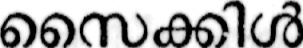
സൈക്കിള്‍
